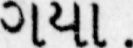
ગયા.
